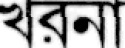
খরনা
